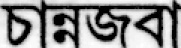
চান্নজবা
